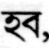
হব,
